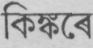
কিঙ্কৰে
